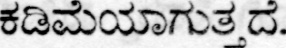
ಕಡಿಮೆಯಾಗುತ್ತದೆ.
